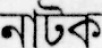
নাটক
